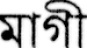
মাগী
